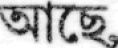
আছে,
